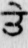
ਤੇ
